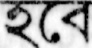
হবে
